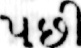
પછી
